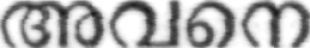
അവനെ
